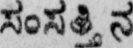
ಸಂಸತ್ತಿನ
